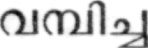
വമ്പിച്ച
